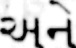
અને
